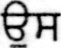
ਉਸ
